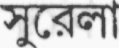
সুরেলা
